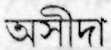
অসীদা
